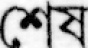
শেষ
